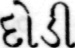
દોડી
